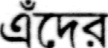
এঁদের
